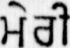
ਮੇਰੀ
